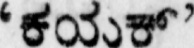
‘ಕಯಕ್’
